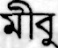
মীবু
